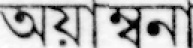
অয়াম্বনা
